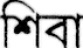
শিবা
